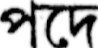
পদে
